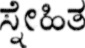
ಸ್ನೇಹಿತ
